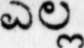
ಎಲ್ಲ
